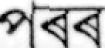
পৰৰ
